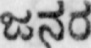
ಜನರ
